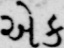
એક
